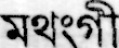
মথংগী
